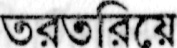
তরতরিয়ে
